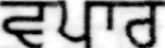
ਵਪਾਰ
